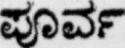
ಪೂರ್ವ
